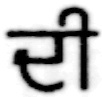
ਦੀ
